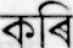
কৰি
